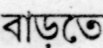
বাড়তে
